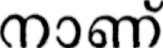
നാണ്
